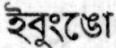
ইবুংঙো
